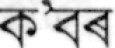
ক'বৰ
